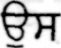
ਉਸ
